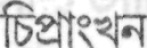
চিপ্ৰাংখন
